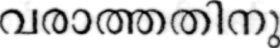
വരാത്തതിനു
